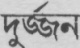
দুৰ্জ্জন
